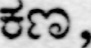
ಕಣ,
